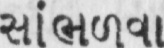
સાંભળવા
